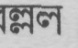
বল্লল
